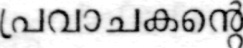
പ്രവാചകന്റെ
